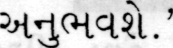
અનુભવશે.'
